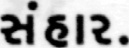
સંહાર.
